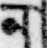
না
